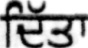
ਦਿੱਤਾ
